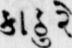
કાઠુરે
